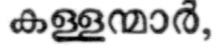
കള്ളന്മാര്‍,
